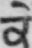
ਕੇ
